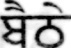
ਬੈਠੇ
